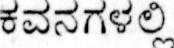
ಕವನಗಳಲ್ಲಿ
